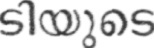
ടിയുടെ
